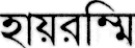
হায়রম্মি
